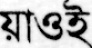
য়াওই
